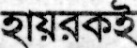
হায়রকই
